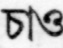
চাও
